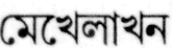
মেখেলাখন
